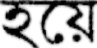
হয়ে
